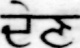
ਦੇਣ
